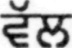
ਵੱਲ
